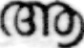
ആ
